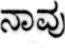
ನಾವು
